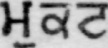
ਮੁਕਟ
